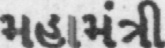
મહામંત્રી
